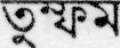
তুম্ফম
